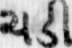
ચડી
